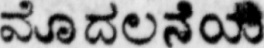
ಮೊದಲನೆಯ
